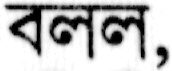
বলল,
